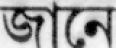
জানে
